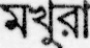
মখুরা
